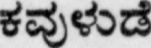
ಕವುಳುಡೆ
